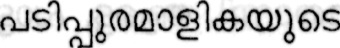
പടിപ്പുരമാളികയുടെ
